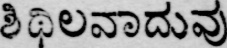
ಶಿಥಿಲವಾದುವು
